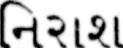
નિરાશ
